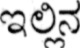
ಇಲ್ಲಿನ
